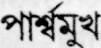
পার্শ্বমুখ
